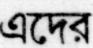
এদের
